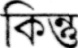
কিন্তু
